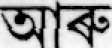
আৰু
